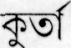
কুর্তা
